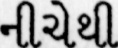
નીચેથી
